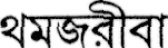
থমজরীবা
